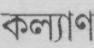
কল্যাণ
